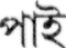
পাই
